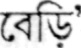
বেড়ি’
